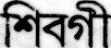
শিবগী
